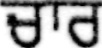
ਚਾਰ
